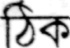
ঠিক
